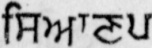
ਸਿਆਣਪ
